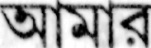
আমার
